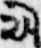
એ
